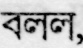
বলল,
